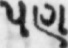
પણ
